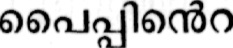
പൈപ്പിന്റെ
